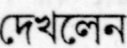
দেখলেন
